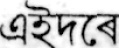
এইদৰে
